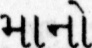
માનો
